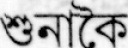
শুনাকৈ
